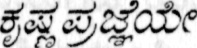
ಕೃಷ್ಣಪ್ರಜ್ಞೆಯೇ
